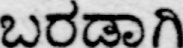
ಬರಡಾಗಿ
